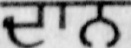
ਦਾਨ
